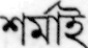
শৰ্মাই
